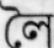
লৈ
